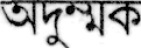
অদুম্মক
